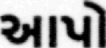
આપો
